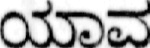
ಯಾವ
